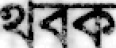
থবক
